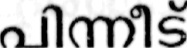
പിന്നീട്
